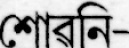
শোৱনি-
